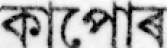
কাপোৰ
